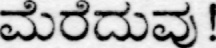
ಮೆರೆದುವು!
